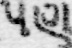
પણ
